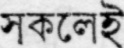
সকলেই
